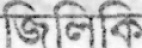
জিলিকি
